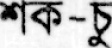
শক-চু
